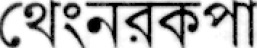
থেংনরকপা
